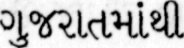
ગુજરાતમાંથી
